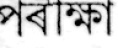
পৰীক্ষা
